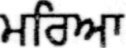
ਮਰਿਆ
